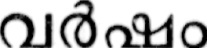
വര്‍ഷം
